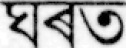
ঘৰত
